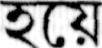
হয়ে
